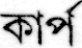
কার্প
